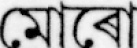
মোৰো
